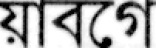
য়াবগে
